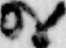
જ
